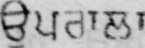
ਉਪਰਾਲਾ
